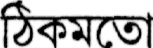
ঠিকমতো
